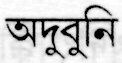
অদুবুনি
